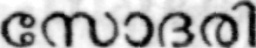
സോദരി
